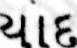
યાદ
